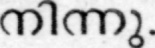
നിന്നു.
